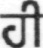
ਹੀ
